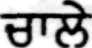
ਚਾਲੇ
